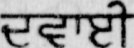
ਦਵਾਈ
